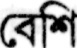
বেশি
